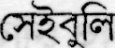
সেইবুলি
